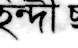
হিন্দী
